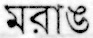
মরাঙ
